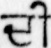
ਦੀ
